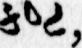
કષ્ટ,
